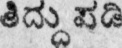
ತಿದ್ದುಪಡಿ
